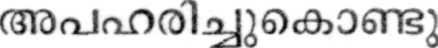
അപഹരിച്ചുകൊണ്ടു
